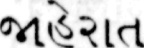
જાહેરાત
